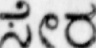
ಸೇರ
